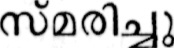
സ്മരിച്ചു
